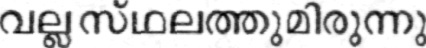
വല്ലസ്ഥലത്തുമിരുന്നു
